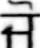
ਜੋ
